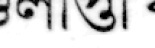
গুলাপ্তা
